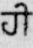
ਹੀ
